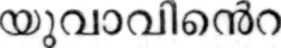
യുവാവിന്റെ
